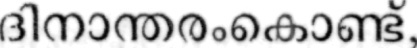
ദിനാന്തരംകൊണ്ട്,
